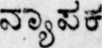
ವ್ಯಾಪಕ
